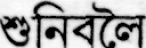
শুনিবলৈ
